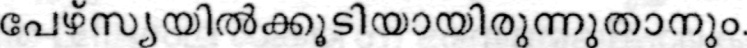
പേഴ്സ്യയില്‍ക്കൂടിയായിരുന്നുതാനും.
